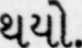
થયો.
